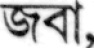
জবা,
